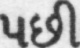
પછી
